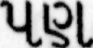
પણ
